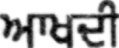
ਆਖਦੀ
